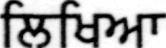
ਲਿਖਿਆ
